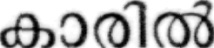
കാരില്‍
